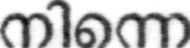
നിന്നെ
